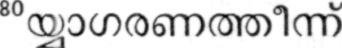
80യ്യാഗരണത്തീന്ന്
